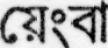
য়েংবা
